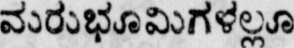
ಮರುಭೂಮಿಗಳಲ್ಲೂ
